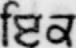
ਇਕ
